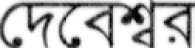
দেবেশ্বর
